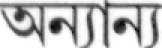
অন্যান্য
